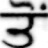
ਤੋਂ
